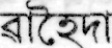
ৱাহৈদা
